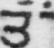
ਤੋਂ
